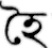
হৈ
